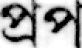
প্রপ
